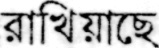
রাখিয়াছে
